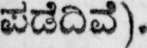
ಪಡೆದಿವೆ).
